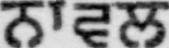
ਨਾਵਲ
